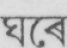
ঘৰে
